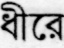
ধীরে
